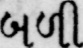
બળી
